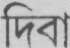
দিবা
